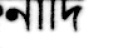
ফিনাদি
